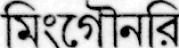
মিংগৌনরি
